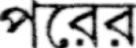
পরের
